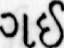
ગઈ
